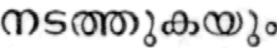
നടത്തുകയും
